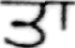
ਤਾਂ
